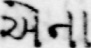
એના
